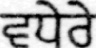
ਵਧੇਰੇ
